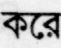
করে
